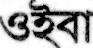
ওইবা
